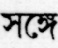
সঙ্গে
